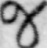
જ
